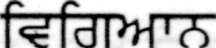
ਵਿਗਿਆਨ
